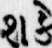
શકે
